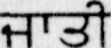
ਜਾਤੀ
